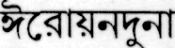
ঈরোয়নদুনা
